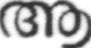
ആ
